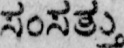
ಸಂಸತ್ತು
